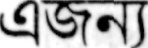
এজন্য
